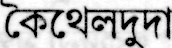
কৈথেলদুদা
